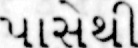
પાસેથી
